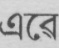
এৱে
